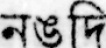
নঙদি
